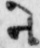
ને
